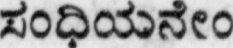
ಸಂಧಿಯನೇಂ
